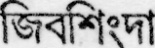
জিবশিংদা
